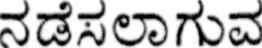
ನಡೆಸಲಾಗುವ
